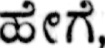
ಹೇಗೆ,
